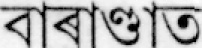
বাৰাণ্ডাত
